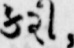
કરી,
